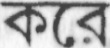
করে
